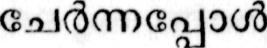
ചേര്‍ന്നപ്പോള്‍
